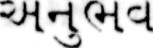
અનુભવ
